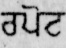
ਰਪੋਟ
